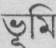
ভূমি
